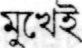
মুখেই
